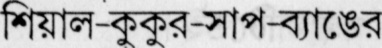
শিয়াল-কুকুর-সাপ-ব্যাঙের
